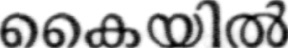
കൈയില്‍
